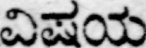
ವಿಷಯ
